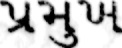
પ્રમુખ
